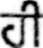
ਹੀ
